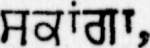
ਸਕਾਂਗਾ,
